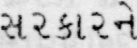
સરકારને
